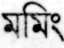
মমিং
